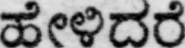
ಹೇಳಿದರೆ
